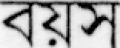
বয়স
